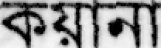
কয়ানা
